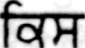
ਕਿਸ
